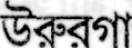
উরুরগা
